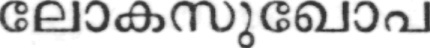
ലോകസുഖോപ
